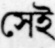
সেই
